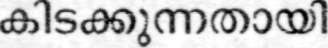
കിടക്കുന്നതായി
